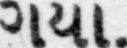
ગયા.
